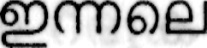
ഇന്നലെ
